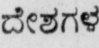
ದೇಶಗಳ
